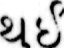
થઈ
